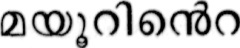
മയൂറിന്റെ
